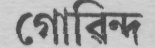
গোৱিন্দ
